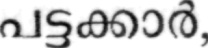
പട്ടക്കാര്‍,
